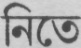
নিতে
